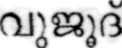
വുജൂദ്
